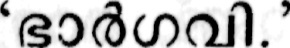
‘ഭാര്‍ഗവി.’
